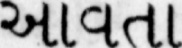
આવતા
